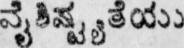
ವೈಶಿಷ್ಟ್ಯತೆಯು
